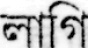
লাগি
